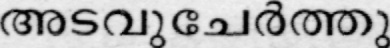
അടവുചേര്‍ത്തു
